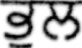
ਭੁਲ
